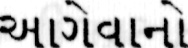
આગેવાનો
